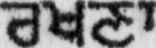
ਰਖਣਾ
